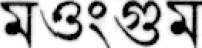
মওংগুম
